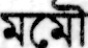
মমৌ
